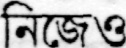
নিজেও
